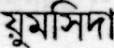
য়ুমসিদা
